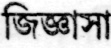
জিজ্ঞাসা
